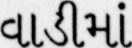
વાડીમાં
